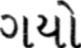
ગયો
